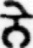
ਨੇ
